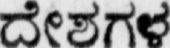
ದೇಶಗಳ
